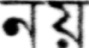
নয়
